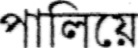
পালিয়ে
